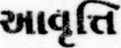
આવૃત્તિ
